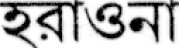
হরাওনা
